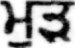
ਮੁੜ
